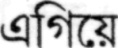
এগিয়ে
